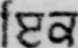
ਇਕ
